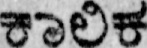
ಕಾಲಿಕ
